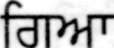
ਗਿਆ
